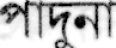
পাদুনা
